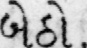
બેઠો.
